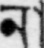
না
